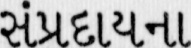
સંપ્રદાયના
